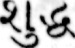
શુદ્ધ
